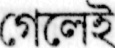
গেলেই
